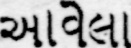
આવેલા
